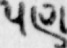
પણ
